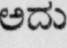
ಅದು
